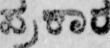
ಪ್ರಕಾರ
